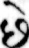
છે
